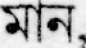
মান,
